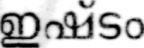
ഇഷ്ടം
